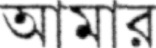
আমার
